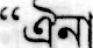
“ঐনা
